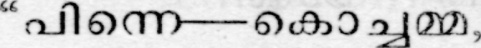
"പിന്നെ-കൊച്ചമ്മ,
